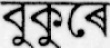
বুকুৰে
